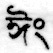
ঈং
